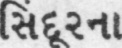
સિંદૂરના
